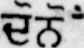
ਦੋਨੋਂ
